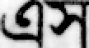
এস
